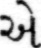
એ
